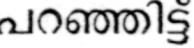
പറഞ്ഞിട്ട്
